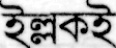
ইল্লকই
